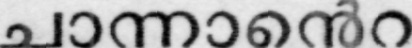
ചാന്നാന്റെ
